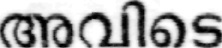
അവിടെ
